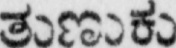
ತುಣುಕು
